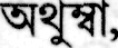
অথুম্বা,
